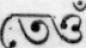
তেওঁ
